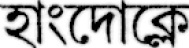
হাংদোক্লে
